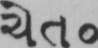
ચેત.
